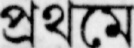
প্রথমে
